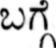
ಬಗ್ಗೆ
